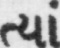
ત્યાં
